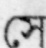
সে
